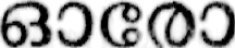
ഓരോ
